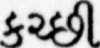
કચ્છી
